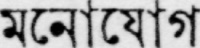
মনোযোগ
